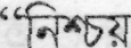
"নিশ্চয়
